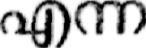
എന്ന
